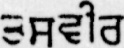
ਤਸਵੀਰ
